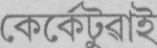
কেৰ্কেটুৱাই
